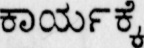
ಕಾರ್ಯಕ್ಕೆ
